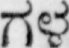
ಗಳ
